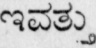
ಇವತ್ತು
